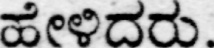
ಹೇಳಿದರು.
